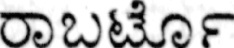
ರಾಬರ್ಟೊ
